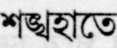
শঙ্খহাতে
